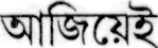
আজিয়েই
